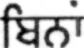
ਬਿਨਾਂ
